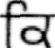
ਕਿ
